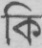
কি
